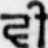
ਵੀ
